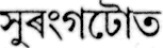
সুৰংগটোত
